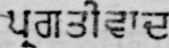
ਪ੍ਰਗਤੀਵਾਦ
